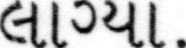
લાગ્યા.
